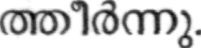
ത്തീര്‍ന്നു.
